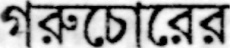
গরুচোরের
